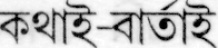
কথাই-বাৰ্তাই
